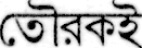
তৌরকই
